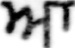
ਆ
